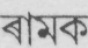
ৰামক
